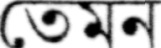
তেমন
